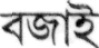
বজাই
